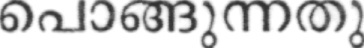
പൊങ്ങുന്നതു
